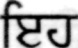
ਇਹ
